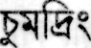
চুমদ্রিং
